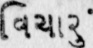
વિચારું
